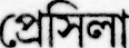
প্রেসিলা
